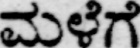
ಮಳೆಗೆ
